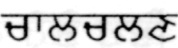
ਚਾਲਚਲਣ
